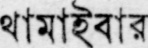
থামাইবার
